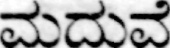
ಮದುವೆ
